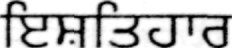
ਇਸ਼ਤਿਹਾਰ
